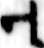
ન
